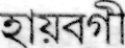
হায়বগী
